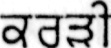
ਕਰੜੀ
